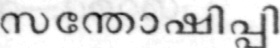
സന്തോഷിപ്പി
